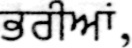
ਭਰੀਆਂ,
